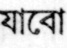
যাবো
